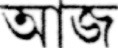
আজ
